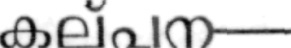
കല്പന-
